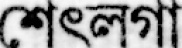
শেৎলগা
